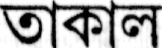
তাকাল
